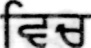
ਵਿਚ
